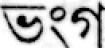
ভংগ
